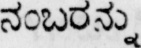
ನಂಬರನ್ನು
